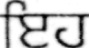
ਇਹ
